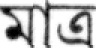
মাত্র
